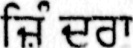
ਜ਼ਿੰਦਰਾ
